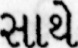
સાથે
